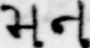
મન
